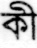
কী
